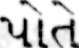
પોતે
